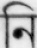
নি
